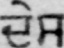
ਦੇਸ
